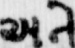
અને
